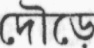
দৌড়ে
